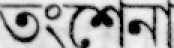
তংশেনা
